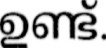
ഉണ്ട്.
